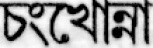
চংখোন্না
